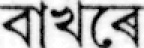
বাখৰে
